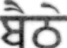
ਬੈਠੇ
